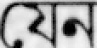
যেন
